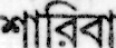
শারিবা
